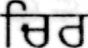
ਚਿਰ
